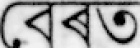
বেৰত
